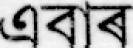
এবাৰ
